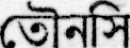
তৌনসি
